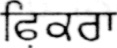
ਫ਼ਿਕਰਾ
